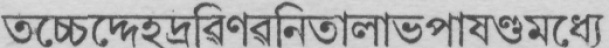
তচ্চেদ্দেহদ্ৰৱিণৱনিতালাভপাষণ্ডমধ্যে
